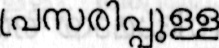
പ്രസരിപ്പുള്ള
